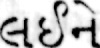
લઈને
